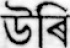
উৰি
